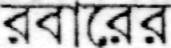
রবারের
